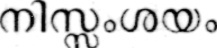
നിസ്സംശയം
